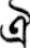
ঐ
